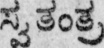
ಸ್ವತಂತ್ರ
